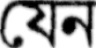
যেন
